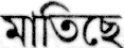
মাতিছে
